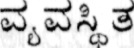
ವ್ಯವಸ್ಥಿತ
